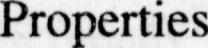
Properties
